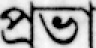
প্রভা
